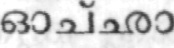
ഓച്ഛാ
